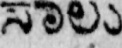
ಸಾಲು
